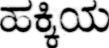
ಹಕ್ಕಿಯ
